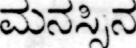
ಮನಸ್ಸಿನ
